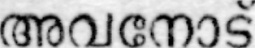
അവനോട്
